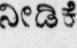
ನೀಡಿದೆ
